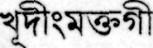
খূদীংমক্তগী
